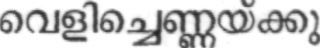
വെളിച്ചെണ്ണയ്ക്കു
